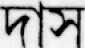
দাস
